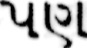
પણ
